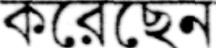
করেছেন
